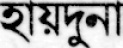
হায়দুনা
